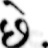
છે.
